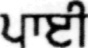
ਪਾਈ
